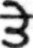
ਤੇ
